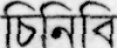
চিনিবি
